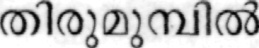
തിരുമുമ്പില്‍
